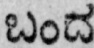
ಬಂದ
